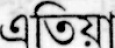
এতিয়া
